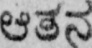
ಆತನ
